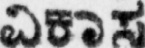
ವಿಕಾಸ
